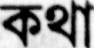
কথা
